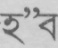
হ"ব
